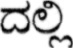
ದಲ್ಲಿ
